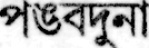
পঙবদুনা
